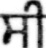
ਸੀ
